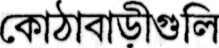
কোঠাবাড়ীগুলি
